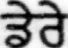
ਡੇਰੇ
